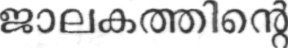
ജാലകത്തിന്റെ
